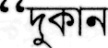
“দুকান
